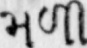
મળી
